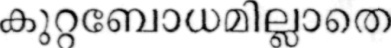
കുറ്റബോധമില്ലാതെ
